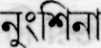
নুংশিনা
